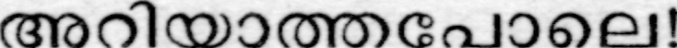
അറിയാത്തപോലെ!
